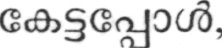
കേട്ടപ്പോള്‍,
